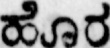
ಹೊರ
